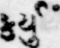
કર્યું
